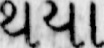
થયા
